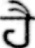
ਹੈ
